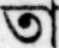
তা
